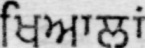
ਖਿਆਲਾਂ
